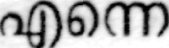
എന്നെ
